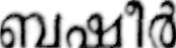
ബഷീര്‍
